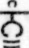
ਨੂੰ
